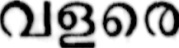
വളരെ
